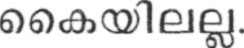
കൈയിലല്ല.
